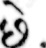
છે.
